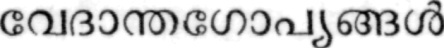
വേദാന്തഗോപ്യങ്ങള്‍
